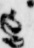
હું
